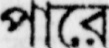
পারে
